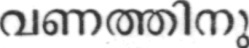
വണത്തിനു
